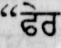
''ਫੇਰ
